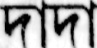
দাদা
